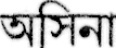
অসিনা
